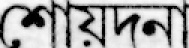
শোয়দনা
